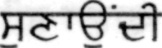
ਸੁਣਾਉਂਦੀ
